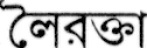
লৈরক্তা
